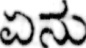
ಏನು
